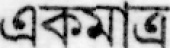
একমাত্র
